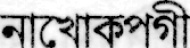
নাখোকপগী
